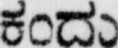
ಕಂದು
